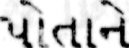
પોતાને
